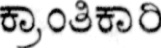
ಕ್ರಾಂತಿಕಾರಿ
